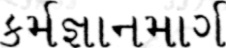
કર્મજ્ઞાનમાર્ગ
